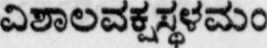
ವಿಶಾಲವಕ್ಷಸ್ಥಳಮಂ
